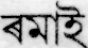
ৰমাই
